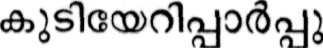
കുടിയേറിപ്പാര്‍പ്പു
